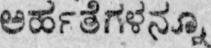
ಅರ್ಹತೆಗಳನ್ನೂ
